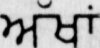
ਅੱਖਾਂ
